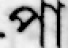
পা
